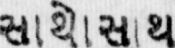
સાથોસાથ
